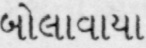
બોલાવાયા
